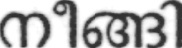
നീങ്ങി
